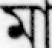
মা
